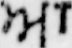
ਆ
